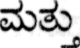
ಮತ್ತು
